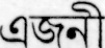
এজনী
